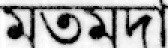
মতমদা
